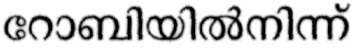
റോബിയില്‍നിന്ന്
